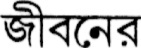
জীবনের
